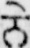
ਨੇ
